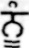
ਨੂੰ
